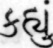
કહ્યું
